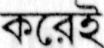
করেই
